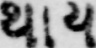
થાય
